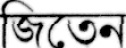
জিতেন
